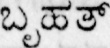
ಬೃಹತ್
